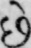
છે
